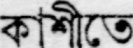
কাশীতে
